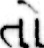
તો
